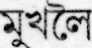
মুখলৈ
